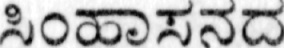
ಸಿಂಹಾಸನದ
